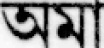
অম
